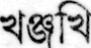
খঞ্জখি
